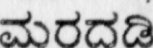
ಮರದಡಿ
